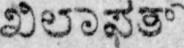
ಖಿಲಾಫತ್
